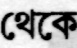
থেকে
